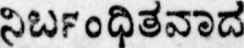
ನಿರ್ಬಂಧಿತವಾದ
